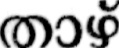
താഴ്
